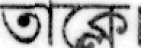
তাক্লে।
